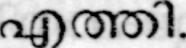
എത്തി.
